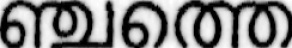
ഞ്ചത്തെ
